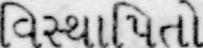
વિસ્થાપિતો
